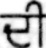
ਦੀ
